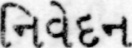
નિવેદન
